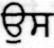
ਉਸ
